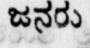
ಜನರು
